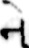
ને
